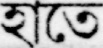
হাতে
